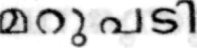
മറുപടി
